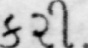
કરી.
